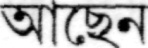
আছেন
